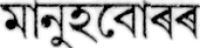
মানুহবোৰৰ
